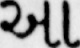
આ
